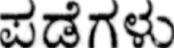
ಪಡೆಗಳು
